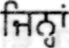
ਜਿਨ੍ਹਾਂ
